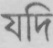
যদি
